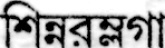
শিন্নরম্লগা
